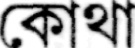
কোথা
